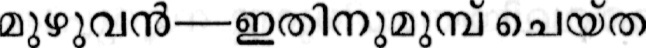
മുഴുവന്‍-ഇതിനുമുചേയ്‌ത
